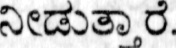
ನೀಡುತ್ತಾರೆ.
